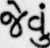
જેવું
